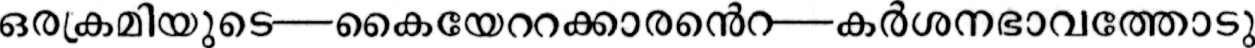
ഒരക്രമിയുടെ-കൈയേറ്റക്കാരന്റെ-കര്‍ശനഭാവത്തോടു
